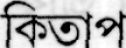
কিতাপ
